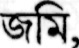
জমি,
